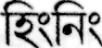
হিংনিং
